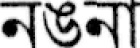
নঙনা
